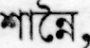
শান্নৈ,
